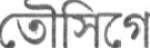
তৌসিগে
